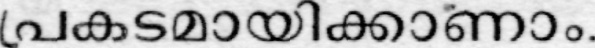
പ്രകടമായിക്കാണാം.
